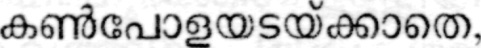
കണ്‍പോളയടയ്ക്കാതെ,
